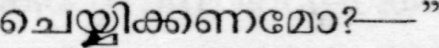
ചെയ്യിക്കണമോ?-"
